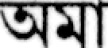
অমা
